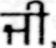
ਜੀ,
